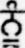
ਨੂੰ
